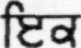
ਇਕ
